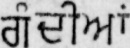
ਗੰਦੀਆਂ
